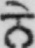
ਨੇ
